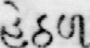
હેઠળ
